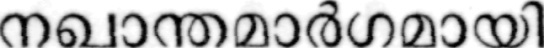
നഖാന്തമാര്‍ഗമായി
